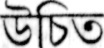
উচিত
